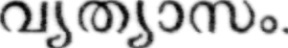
വ്യത്യാസം.
